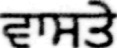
ਵਾਸਤੇ
